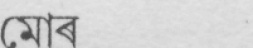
মোৰ
